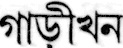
গাড়ীখন
